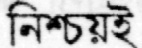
নিশ্চয়ই
